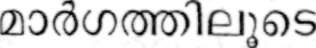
മാര്‍ഗത്തിലൂടെ
